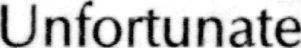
Unfortunate
